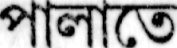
পালাতে
